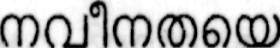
നവീനതയെ
